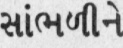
સાંભળીને
